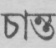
চান্ত
